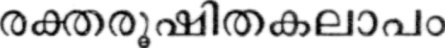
രക്തരൂഷിതകലാപം
